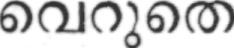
വെറുതെ
